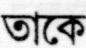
তাকে
